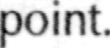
point.
